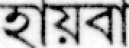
হায়বা
